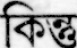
কিন্তু
